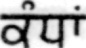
ਕੰਧਾਂ
